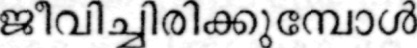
ജീവിച്ചിരിക്കുമ്പോള്‍
